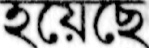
হয়েছে
